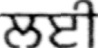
ਲਈ
